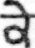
ਕੇ
